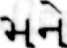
મને
